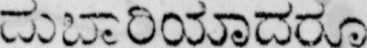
ದುಬಾರಿಯಾದರೂ
